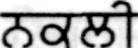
ਨਕਲੀ
